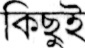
কিছুই
